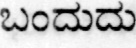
ಬಂದುದು
